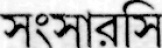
সংসারসি
